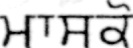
ਮਾਸਕੋ
